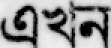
এখন
